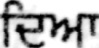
ਦਿਆ
